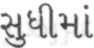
સુધીમાં
